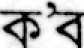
ক'ব
